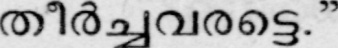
തീര്‍ച്ചവരട്ടെ.”
